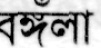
বঙ্গঁলা
